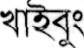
খাইবুং
